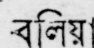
বলিয়া
